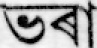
ভৰা
